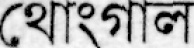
থোংগাল
